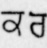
ਕਰ
